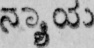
ನ್ಯಾಯ
